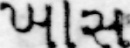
ખાસ
